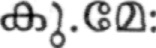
കു.മേ:
